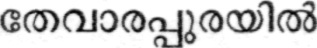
തേവാരപ്പുരയില്‍
